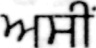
ਅਸੀਂ
